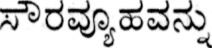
ಸೌರವ್ಯೂಹವನ್ನು
